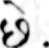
છે.
